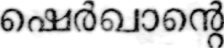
ഷെര്‍ഖാന്റെ
